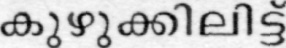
കുഴുക്കിലിട്ട്
